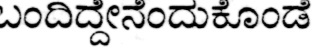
ಬಂದಿದ್ದೇನೆಂದುಕೊಂಡೆ
